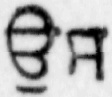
ਉਸ
